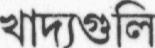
খাদ্যগুলি
